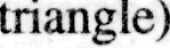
triangle)
